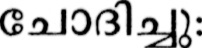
ചോദിച്ചു:
